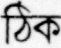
ঠিক
